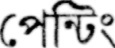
পেন্টিং
